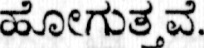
ಹೋಗುತ್ತವೆ.
